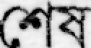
শেষ
